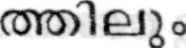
ത്തിലും
